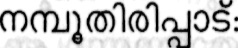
നമ്പൂതിരിപ്പാട്:
